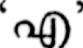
‘എ’
